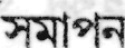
সমাপন
